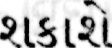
શકાશે
